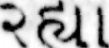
રહ્યા
